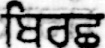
ਬਿਰਛ
